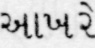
આખરે
